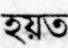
হয়ত
